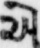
એ
